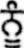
ਨੂੰ
